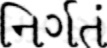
નિર્ગતં
